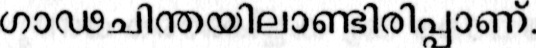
ഗാഢചിന്തയിലാണ്ടിരിപ്പാണ്.
